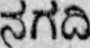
ನಗದಿ
